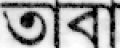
তাবা
